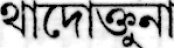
থাদোক্তুনা
